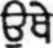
ਉਥੇ
